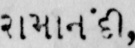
રામાનંદી,
